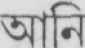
আনি
